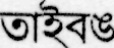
তাইবঙ
